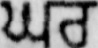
ਘਰ
